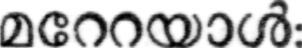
മറ്റേയാള്‍:
